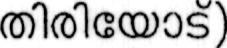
തിരിയോട്)
